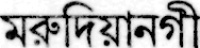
মরুদিয়ানগী
